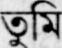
তুমি
